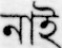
নাই
